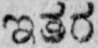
ಇತರ
